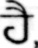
ਹੈ,
